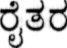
ರೈತರ
